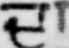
ਦਾ
